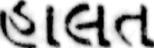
હાલત
